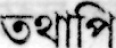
তথাপি
